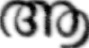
ആ
